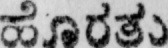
ಹೊರತು
